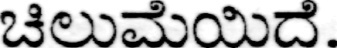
ಚಿಲುಮೆಯಿದೆ.
